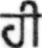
ਹੀ
